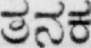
ತನಕ
